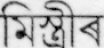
মিস্ত্রীৰ
